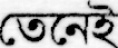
তেনেই
